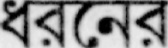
ধরনের
